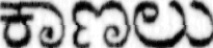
ಕಾಣಲು
